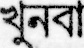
খুনবা
